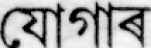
যোগাৰ
